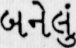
બનેલું
